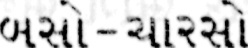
બસો-ચારસો
